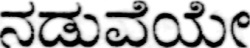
ನಡುವೆಯೇ
